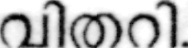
വിതറി.
